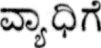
ವ್ಯಾಧಿಗೆ
